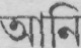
আনি
